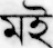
মই
